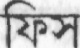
ফিস
